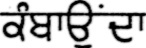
ਕੰਬਾਉਂਦਾ
